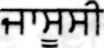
ਜਾਸੂਸੀ
